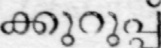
ക്കുറുപ്പ്
